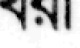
খরা
